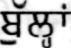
ਬੁੱਲ੍ਹਾਂ
